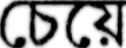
চেয়ে
